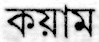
কয়াম
